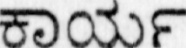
ಕಾರ್ಯ
